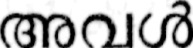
അവള്‍
